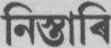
নিস্তাৰি
